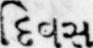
દિવસ
